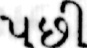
પછી
